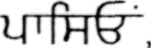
ਪਾਸਿਓਂ,
